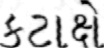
કટાક્ષે
